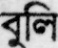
বুলি
